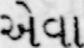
એવા
